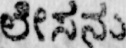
ಲೇಸನು
